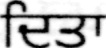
ਦਿਤਾ
